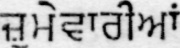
ਜ਼ੁਮੇਵਾਰੀਆਂ
